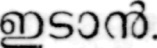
ഇടാന്‍.
